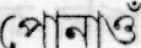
পোনাওঁ
